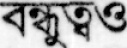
বন্ধুত্বও
